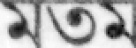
মতম
